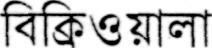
বিক্রিওয়ালা
